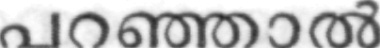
പറഞ്ഞാല്‍
